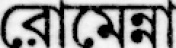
রোমেন্না
